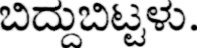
ಬಿದ್ದುಬಿಟ್ಟಳು.
